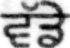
ਵੱਡੇ
